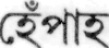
হেঁপাহ
